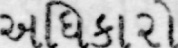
અધિકારો
